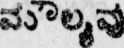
ಮೌಲ್ಯವು
